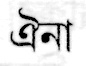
ঐনা
